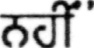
ਨਹੀਂ''
